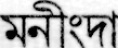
মনীংদা
